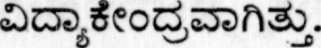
ವಿದ್ಯಾಕೇಂದ್ರವಾಗಿತ್ತು.
